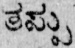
ತಪ್ಪು
